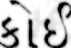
કોઈ
